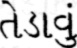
તેડાવું
